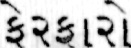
ફેરફારો
